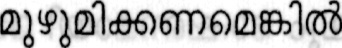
മുഴുമിക്കണമെങ്കില്‍
